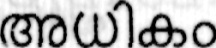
അധികം
